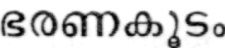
ഭരണകൂടം
